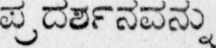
ಪ್ರದರ್ಶನವನ್ನು
